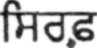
ਸਿਰਫ਼
